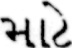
માટે
